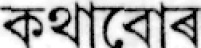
কথাবোৰ
